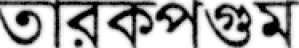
তারকপগুম
